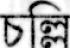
চল্লি
